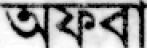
অফবা
